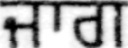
ਜਾਗ
